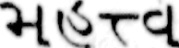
મહત્ત્વ
